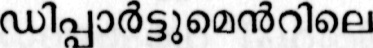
ഡിപ്പാര്‍ട്ടുമെന്റിലെ
